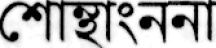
শোন্থাংননা
